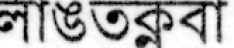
লাঙতক্নবা
